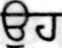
ਉਹ
